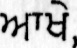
ਆਖੇ,
